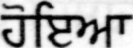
ਹੋਇਆ
